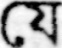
যে
